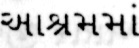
આશ્રમમાં
